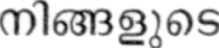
നിങ്ങളുടെ
